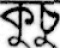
কুচু
